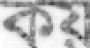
কয়
